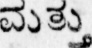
ಮತ್ತು
